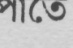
পাতে
